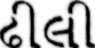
ઢીલી
